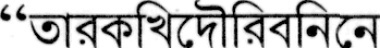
“তারকখিদৌরিবনিনে
